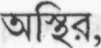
অস্থির,
